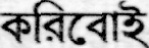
করিবোই
